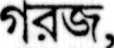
গরজ,
